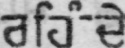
ਰਹਿੰਦੇ
